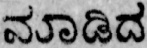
ಮಾಡಿದ
